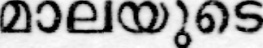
മാലയുടെ
